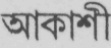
আকাশী
